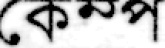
কেম্প
